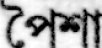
পৈশা
